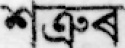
শত্রুৰ
